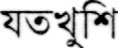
যতখুশি
